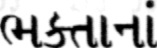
ભક્તાનાં
